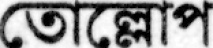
তোল্লোপ
